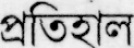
প্রতিহাল
